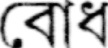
বোধ
